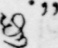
છું"
